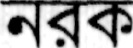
নরক
